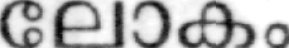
ലോകം
